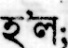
হ'ল;
